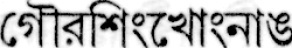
গৌরশিংখোংনাঙ
